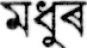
মধুৰ
